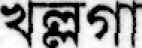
খল্লগা
